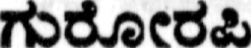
ಗುರೋರಪಿ
